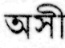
অসী
